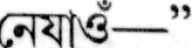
নেযাওঁ-"
